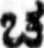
ಚ
